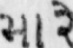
મારે
